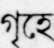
গৃহে
